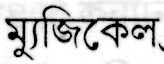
ম্যুজিকেল
